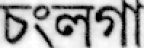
চংলগা
